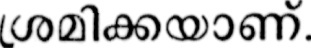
ശ്രമിക്കയാണ്.
